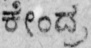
ಕೇಂದ್ರ
